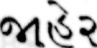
જાહેર
